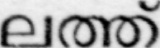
ലത്ത്
